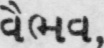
વૈભવ,
